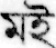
মই
